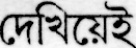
দেখিয়েই
